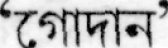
‘গোদান’
